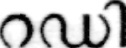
റഡി
